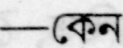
–কেন
